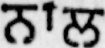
ਨਾਲ
